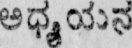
ಅಧ್ಯಯನ
